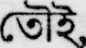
তৌই,
